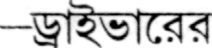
-ড্রাইভারের
